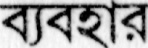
ব্যবহার
